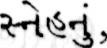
સ્નેહનું,
